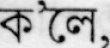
ক'লে,
